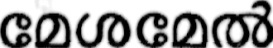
മേശമേല്‍
